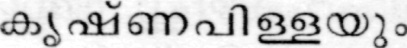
കൃഷ്ണപിള്ളയും
